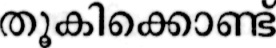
തൂകിക്കൊണ്ട്
